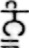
ਨੂੰ
